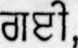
ਗਈ,
